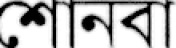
শোনবা
